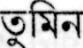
তুমিন
